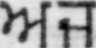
ਅਜ
